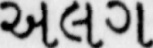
અલગ
